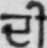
ਦੀ
